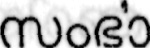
സംഭാ
